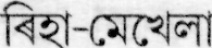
ৰিহা-মেখেলা
